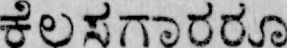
ಕೆಲಸಗಾರರೂ
